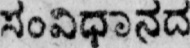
ಸಂವಿಧಾನದ
